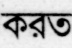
করত
